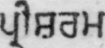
ਪ੍ਰੀਸ਼ਰਮ
